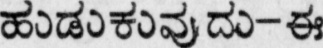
ಹುಡುಕುವುದು-ಈ
